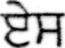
ਏਸ
